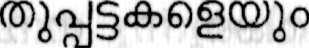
തുപ്പട്ടകളെയും
